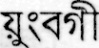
য়ুংবগী
